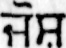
ਜੋਸ਼
